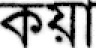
কয়া
